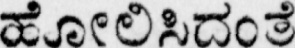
ಹೋಲಿಸಿದಂತೆ
